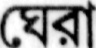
ঘেরা
